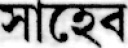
সাহেব
